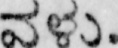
ವಳು.
